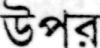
উপর
